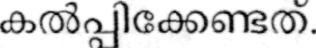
കല്‍പ്പിക്കേണ്ടത്.
